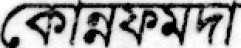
কোন্নফমদা
